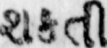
શકતી
